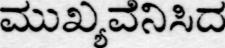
ಮುಖ್ಯವೆನಿಸಿದ
